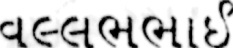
વલ્લભભાઈ
